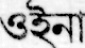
ওইনা
